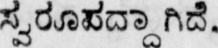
ಸ್ವರೂಪದ್ದಾಗಿದೆ.
